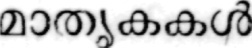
മാതൃകകള്‍
